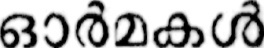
ഓര്‍മകള്‍
